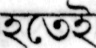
হতেই
